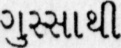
ગુસ્સાથી
